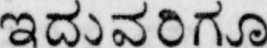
ಇದುವರಿಗೂ
